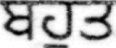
ਬਹੁਤ
